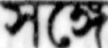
সঙ্গে
